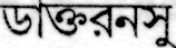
ডাক্তরনসু
